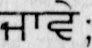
ਜਾਵੇ;
